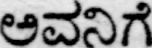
ಅವನಿಗೆ
